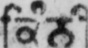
ਕਿੰਨੀ
